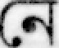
নে
